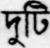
দুটি
